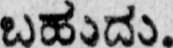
ಬಹುದು.
